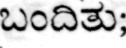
ಬಂದಿತು;
